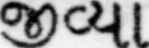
જીવ્યા
